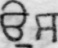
ਉਸ
